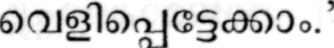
വെളിപ്പെട്ടേക്കാം.'
